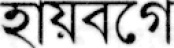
হায়বগে
